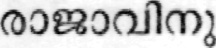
രാജാവിനു
